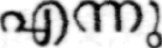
എന്നു
